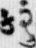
કરું
